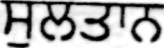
ਸੁਲਤਾਨ
